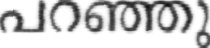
പറഞ്ഞു
